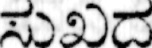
ಸುಖದ
